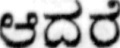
ಆದರೆ
